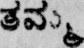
ತಮ್ಮ
